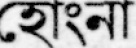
হোংনা
